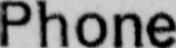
Phone
